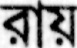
রায়
